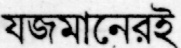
যজমানেরই
